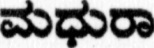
ಮಧುರಾ
